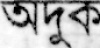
অদুক
